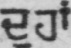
ਦੁਹਾਂ
